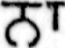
ਨਾ
